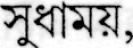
সুধাময়,
